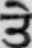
ਤੇ
